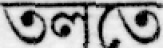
তলতে
